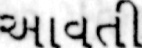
આવતી
